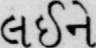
લઈને
